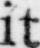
it
